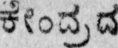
ಕೇಂದ್ರದ
